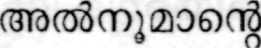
അല്‍നൂമാന്റെ
